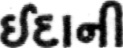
ઈદાની
